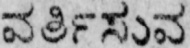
ವರ್ತಿಸುವ
